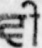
ਵੀ
